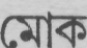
মোক
